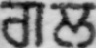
ਗਲ
